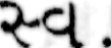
સ્વ.
